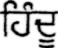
ਹਿੰਦੂ
